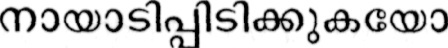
നായാടിപ്പിടിക്കുകയോ
